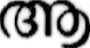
ആ
